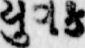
યુવક
